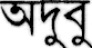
অদুবু
